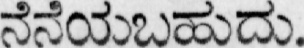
ನೆನೆಯಬಹುದು.
